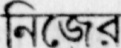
নিজের
